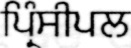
ਪ੍ਰਿੰਸੀਪਲ
